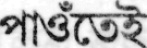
পাওঁতেই
